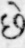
છે
